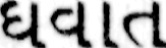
ઘવાત
